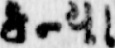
કન્યા
